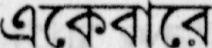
একেবারে
